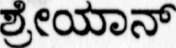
ಶ್ರೇಯಾನ್
